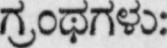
ಗ್ರಂಥಗಳು:
